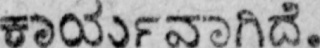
ಕಾರ್ಯವಾಗಿದೆ.
